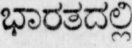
ಭಾರತದಲ್ಲಿ
